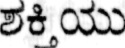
ಶಕ್ತಿಯು
